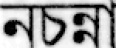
নচন্না
